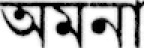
অমনা
